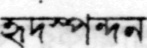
হৃদস্পন্দন
